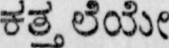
ಕತ್ತಲೆಯೇ
